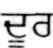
ਦੂਰ
